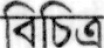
বিচিত্র
